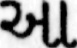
આ
